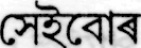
সেইবোৰ
